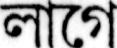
লাগে
